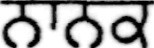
ਨਾਨਕ
